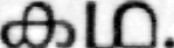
കഥ.
